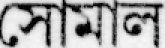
সোমাল
